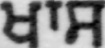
ਖਾਸ
